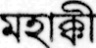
মহাক্কী
